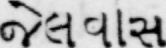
જેલવાસ
